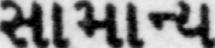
સામાન્ય
